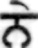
ਨੇ
